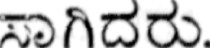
ಸಾಗಿದರು.
